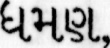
ધમણ,
